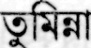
তুমিন্না
